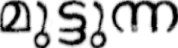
മുട്ടുന്ന
